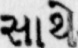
સાથે
